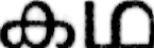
കഥ
